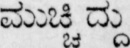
ಮುಚ್ಚಿದ್ದು
